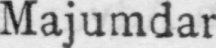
Majumdar
